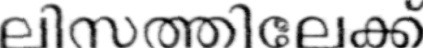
ലിസത്തിലേക്ക്
